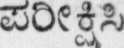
ಪರೀಕ್ಷಿಸಿ
